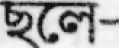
ছলে-
